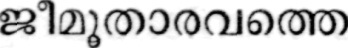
ജീമൂതാരവത്തെ
